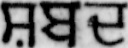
ਸ਼ਬਦ
